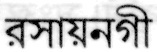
রসায়নগী
